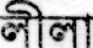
লীলা
